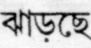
ঝাড়ছে
